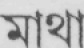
মাথা
